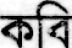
কবি
